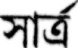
সার্ত্র
